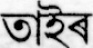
তাইৰ
